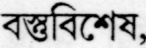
বস্তুবিশেষ,
